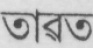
তাৱত
